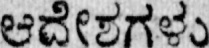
ಆದೇಶಗಳು
